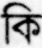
কি
